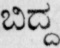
ಬಿದ್ದ
